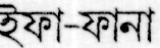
ইফা-ফানা
